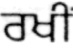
ਰਖੀਂ
